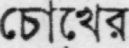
চোখের
